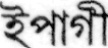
ইপাগী
